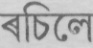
ৰচিলে
